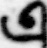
এ
